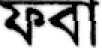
ফবা
